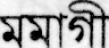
মমাগী
